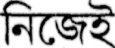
নিজেই
